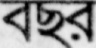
বছর
